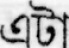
এটা
